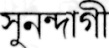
সুনন্দাগী
